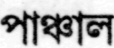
পাঞ্চাল
